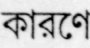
কারণে
